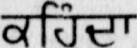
ਕਹਿੰਦਾ
